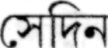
সেদিন
